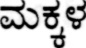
ಮಕ್ಕಳ
